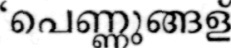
'പെണ്ണുങ്ങള്
